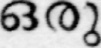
ഒരു
